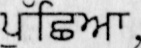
ਪੁੱਛਿਆ,
